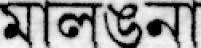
মালঙনা
